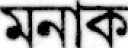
মনাক
